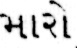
મારો
